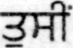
ਤੁਸੀਂ
